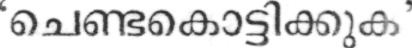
‘ചെണ്ടകൊട്ടിക്കുക'
